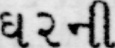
ઘરની
